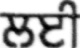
ਲਈ
